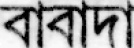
বাবাদা
